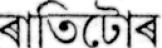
ৰাতিটোৰ
